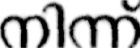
നിന്ന്
